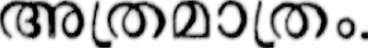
അത്രമാത്രം.
